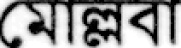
মোল্লবা
